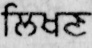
ਲਿਖਣ
